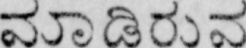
ಮಾಡಿರುವ
